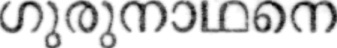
ഗുരുനാഥനെ
